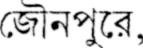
জৌনপুরে,
